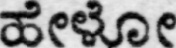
ಹೇಳೋ
